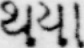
થયા
